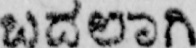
ಬದಲಾಗಿ
